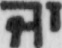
ਜਾ
